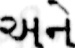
અને
